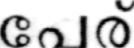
പേര്
